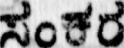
ಸಂಕರ
